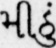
મીઠું
